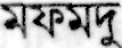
মফমদু
